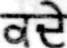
ਕਦੇ
